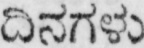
ದಿನಗಳು
